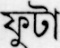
ফুটা
